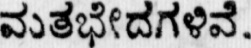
ಮತಭೇದಗಳಿವೆ.
